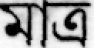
মাত্ৰ
